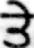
ਤੇ
